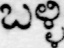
ಬಳ್ಳಿ
